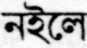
নইলে
